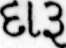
દારૂ
